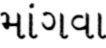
માંગવા
